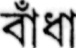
বাঁধা
